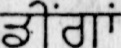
ਡੀਂਗਾਂ
